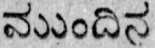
ಮುಂದಿನ
